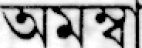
অমম্বা
